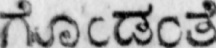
ಗೊಂಡಂತೆ
